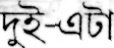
দুই-এটা
